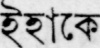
ইহাকে
